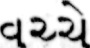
વચ્ચે
